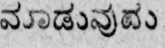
ಮಾಡುವುದು
